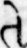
તે
